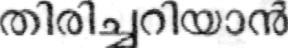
തിരിച്ചറിയാന്‍
